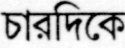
চারদিকে
